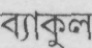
ব্যাকুল
